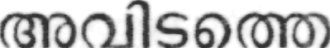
അവിടത്തെ
